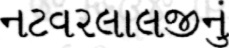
નટવરલાલજીનું
